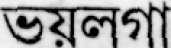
ভয়লগা
